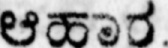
ಆಹಾರ
